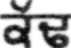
ਕੱਢ
